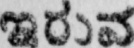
ಇರುವ
